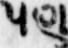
પણ
